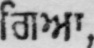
ਗਿਆ,
